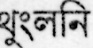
থুংলনি
